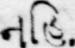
નહિ.
